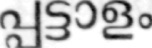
പ്പട്ടാളം
